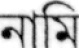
নামি
